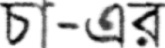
চা-এর
